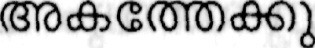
അകത്തേക്കു
